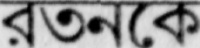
রতনকে
